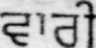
ਵਾਰੀ
